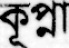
কূপ্না
